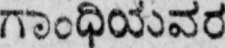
ಗಾಂಧಿಯವರ
